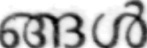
ങ്ങള്‍
